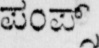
ಪಂಪ್ಸ್
